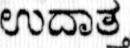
ಉದಾತ್ತ
